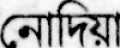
নোদিয়া
